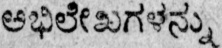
ಅಭಿಲೇಖಗಳನ್ನು
